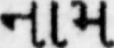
નામ
